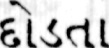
દોડતા
